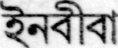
ইনবীবা
